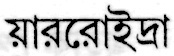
য়াররোইদ্রা
